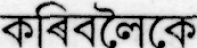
কৰিবলৈকে
